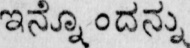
ಇನ್ನೊಂದನ್ನು
